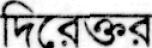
দিরেক্তর
